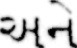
અને
